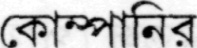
কোম্পানির
